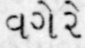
વગેરે
